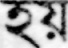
হয়
